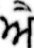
ਐ
